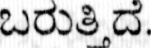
ಬರುತ್ತಿದೆ.
